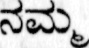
ನಮ್ಮ
